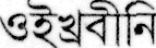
ওইখ্রবীনি
